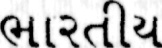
ભારતીય
